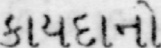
કાયદાનો
